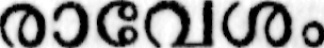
രാവേശം
